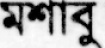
মশাবু
